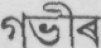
গভীৰ
